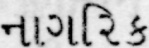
નાગરિક
